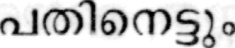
പതിനെട്ടും
